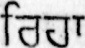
ਰਿਹਾ
